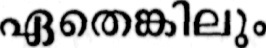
ഏതെങ്കിലും
